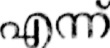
എന്ന്
